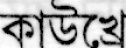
কাউখ্রে
